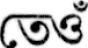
তেওঁ
